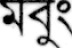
মবুং
